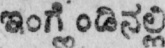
ಇಂಗ್ಲೆಂಡಿನಲ್ಲಿ
